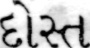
દોસ્ત
